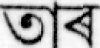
তাৰ
